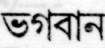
ভগবান
